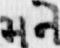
મને
